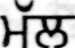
ਮੱਲ
